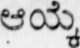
ಆಯ್ಕೆ
